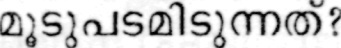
മൂടുപടമിടുന്നത്?
